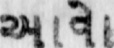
આવો
